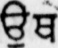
ਉਥੇ
